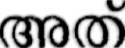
അത്
